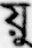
য়ু
